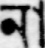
না
